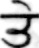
ਤੇ
